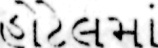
હોટેલમાં
